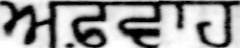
ਅਫ਼ਵਾਹ
